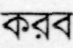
করব
